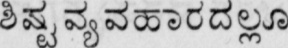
ಶಿಷ್ಟವ್ಯವಹಾರದಲ್ಲೂ
